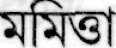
মমিত্তা
